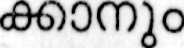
ക്കാനും
